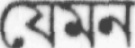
যেমন
